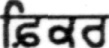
ਫ਼ਿਕਰ
